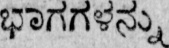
ಭಾಗಗಳನ್ನು
